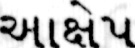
આક્ષેપ
